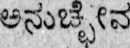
ಅನುಚ್ಛೇದ
